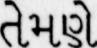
તેમણે
